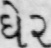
ઘેર
